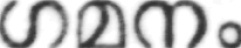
ഗമനം
